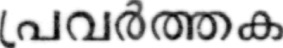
പ്രവര്‍ത്തക
